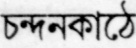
চন্দনকাঠে
